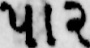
પાર
